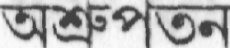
অশ্রুপতন
